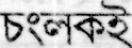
চংলকই
